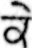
ਕੇ
